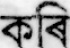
কৰি
